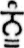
ਨੂੰ
